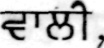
ਵਾਲੀ,
